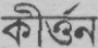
কীৰ্ত্তন
